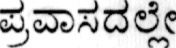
ಪ್ರವಾಸದಲ್ಲೇ
